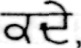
ਕਦੇ,
